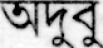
অদুবু
